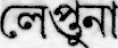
লেপ্তুনা
